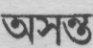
অসন্ত
